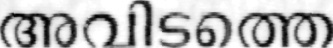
അവിടത്തെ
